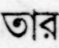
তার
